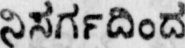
ನಿಸರ್ಗದಿಂದ
